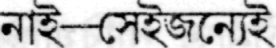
নাই—সেইজন্যেই
